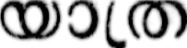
യാത്ര
